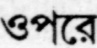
ওপরে
